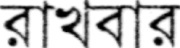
রাখবার
